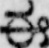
ಈ
